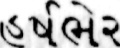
હર્ષભેર
